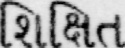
શિક્ષિત
